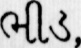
ભીડ,
